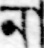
না
